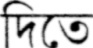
দিতে
